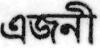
এজনী
